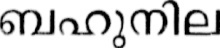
ബഹുനില
